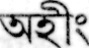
অহীং
